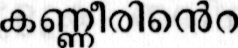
കണ്ണീരിന്റെ
